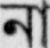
না
